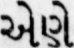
એણે
